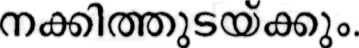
നക്കിത്തുടയ്ക്കും.
